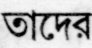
তাদের
